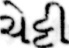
ચેટ્ટી
